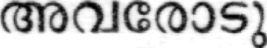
അവരോടു
